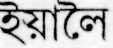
ইয়ালৈ
